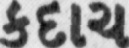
કદાચ
